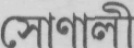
সোণালী
